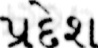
પ્રદેશ
